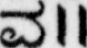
ವ||
